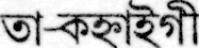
তা-কহ্নাইগী
